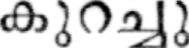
കുറച്ചു
